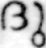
ദു
